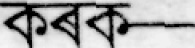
কৰক-
